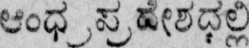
ಆಂಧ್ರಪ್ರದೇಶದಲ್ಲಿ
